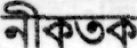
নীকতক
